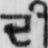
ਦੀ
